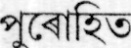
পুৰোহিত
